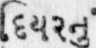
દિયરનું
